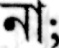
না;
